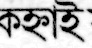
কহ্নাই
